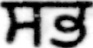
ਸਭ
